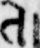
તો
